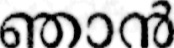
ഞാന്‍
